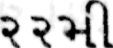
૨૨મી
